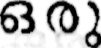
ഒരു
